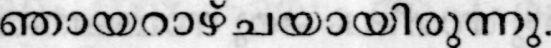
ഞായറാഴ്ചയായിരുന്നു.
